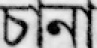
চানা
